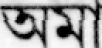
অমা
